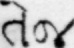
તેજ
